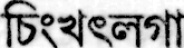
চিংখৎলগা
